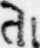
તો
